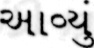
આવ્યું
